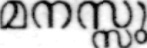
മനസ്സു
